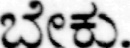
ಬೇಕು.
